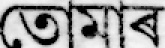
তোমাৰ
